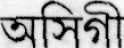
অসিগী
